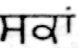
ਸਕਾਂ
